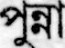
পুন্না
